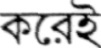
করেই
